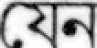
যেন
